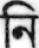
নি
